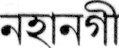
নহানগী
